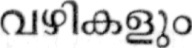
വഴികളും
